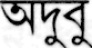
অদুবু
